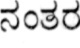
ನಂತರ
